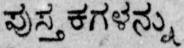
ಪುಸ್ತಕಗಳನ್ನು
